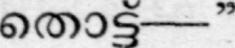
തൊട്ട്-"
